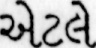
એટલે
